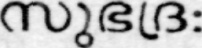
സുഭദ്ര:
